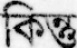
কিন্তু
